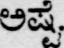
ಅಷ್ಟೆ.
